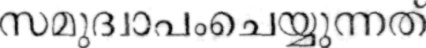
സമുദ്വാപംചെയ്യുന്നത്
